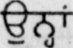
ਉਨ੍ਹਾਂ
